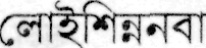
লোইশিন্ননবা
